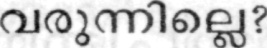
വരുന്നില്ലെ?
